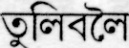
তুলিবলৈ
